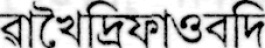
ৱাখৈদ্রিফাওবদি
